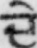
ਦੇ
